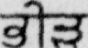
ਭੀੜ
